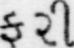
ફરી
